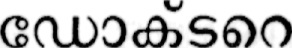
ഡോക്ടറെ
